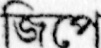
জিপে
